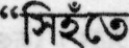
"সিহঁতে
